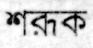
শরূক
